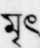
মৃত্
